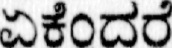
ಏಕೆಂದರೆ
